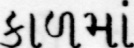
કાળમાં
